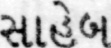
સાહેબ
